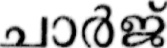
ചാര്‍ജ്
